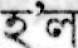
হ'ল
